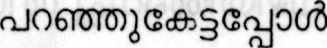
പറഞ്ഞുകേട്ടപ്പോള്‍
